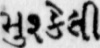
મુશ્કેલી
